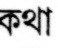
কথা
